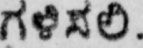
ಗಳಿಸಲಿ.
